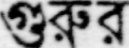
গুরুর
